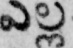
ಎಲ್ಲ
